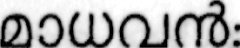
മാധവന്‍:
